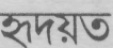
হৃদয়ত
